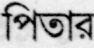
পিতার
